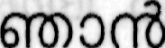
ഞാന്‍
